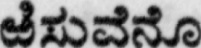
ಱಸುವೆನೊ
